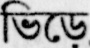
ভিড়ে
